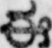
ಈ
